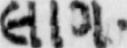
લાગ-
